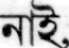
নাই,
